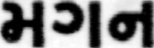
મગન
